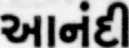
આનંદી
